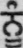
ਨੂੰ
